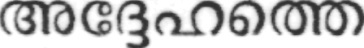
അദ്ദേഹത്തെ
